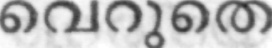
വെറുതെ
